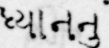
ધ્યાનનું
